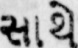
સાથે
